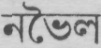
নভৈল
